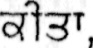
ਕੀਤਾ,
